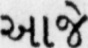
આજે
